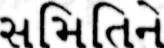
સમિતિને
